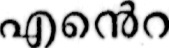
എന്റെ
